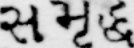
સમુદ્ધ
